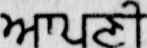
ਆਪਣੀ
